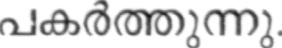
പകര്‍ത്തുന്നു.
